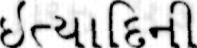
ઇત્યાદિની
